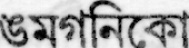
ঙমগনিকো
